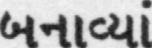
બનાવ્યાં
